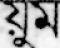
য়ুম
